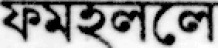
ফমহললে
